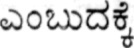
ಎಂಬುದಕ್ಕೆ
